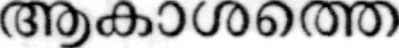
ആകാശത്തെ
